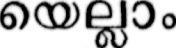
യെല്ലാം
